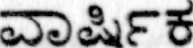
ವಾರ್ಷಿಕ
